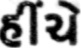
હીંચે
